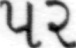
પર
